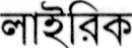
লাইরিক
